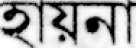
হায়না
